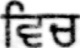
ਵਿਚ
